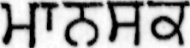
ਮਾਨਸਕ
